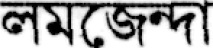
লমজেন্দা
